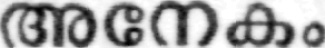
അനേകം
